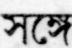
সঙ্গে
